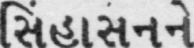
સિંહાસનને
